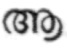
ആ
